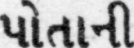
પોતાની
